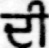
ਦੀ
